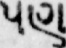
પણ
